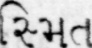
સ્મિત
